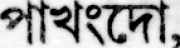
পাখংদো,
